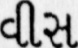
વીસ
